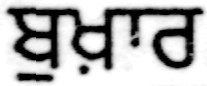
ਬੁਖ਼ਾਰ
